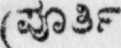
(ಪೂರ್ತಿ
